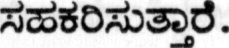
ಸಹಕರಿಸುತ್ತಾರೆ.
